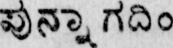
ಪುನ್ನಾಗದಿಂ
